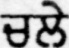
ਚਲੇ
